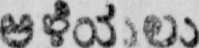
ಅಳೆಯಲು
